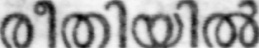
രീതിയില്‍
